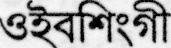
ওইবশিংগী
